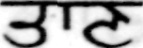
ਤਾਣ
